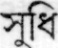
সুধি
